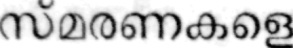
സ്മരണകളെ
